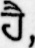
ਹੈ,
